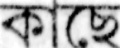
কাছে
